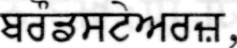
ਬਰੌਡਸਟੇਅਰਜ਼,
